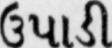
ઉપાડી
